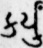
કર્યું
